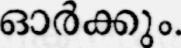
ഓര്‍ക്കും.
